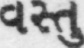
વસ્તુ
